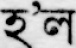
হ'ল
